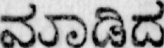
ಮಾಡಿದ
